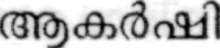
ആകര്‍ഷി
